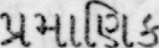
પ્રમાણિક
